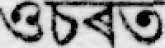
ওচৰত
